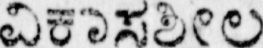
ವಿಕಾಸಶೀಲ
